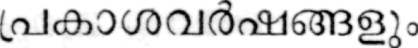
പ്രകാശവര്‍ഷങ്ങളും
